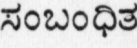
ಸಂಬಂಧಿತ
